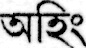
অহিং
